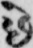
છે
